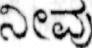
ನೀವು
